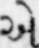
એ
